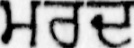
ਮਰਦ
